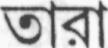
তারা
